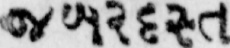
જબરદસ્ત
